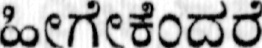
ಹೀಗೇಕೆಂದರೆ
